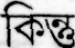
কিন্তু
